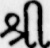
શ્રી
